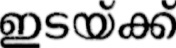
ഇടയ്ക്ക്
